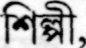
শিল্পী,
